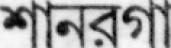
শানরগা
